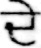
ਦੇ
